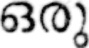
ഒരു
